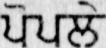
ਪੋਪਲੇ
